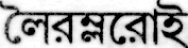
লৈরম্লরোই
